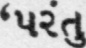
'પરંતુ
